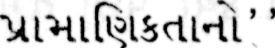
પ્રામાણિકતાનો"
